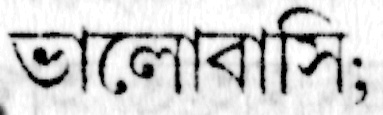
ভালোবাসি;
